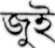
জুই
